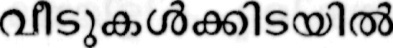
വീടുകള്‍ക്കിടയില്‍
